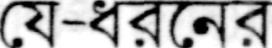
যে-ধরনের
